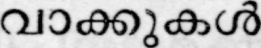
വാക്കുകള്‍
